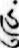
હું
